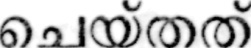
ചെയ്തത്
